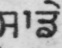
ਸਾਡੇ
